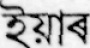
ইয়াৰ
